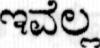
ಇವೆಲ್ಲ
